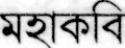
মহাকবি
